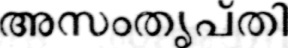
അസംതൃപ്തി
